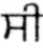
ਸੀ
